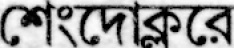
শেংদোক্লরে
